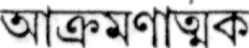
আক্রমণাত্মক
